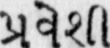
પ્રવેશી
